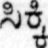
ಸಿಕ್ಕಿ
